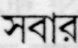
সবার
